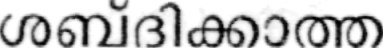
ശബ്ദിക്കാത്ത
